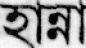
হান্না
